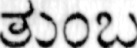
ತುಂಬ
